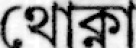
থোক্না
